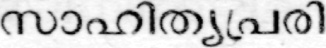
സാഹിത്യപ്രരി
